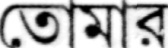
তোমার
